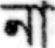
না
